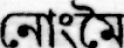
নোংমৈ
